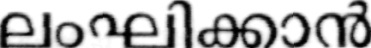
ലംഘിക്കാന്‍
